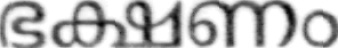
ഭക്ഷണം
